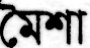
মৈশা
